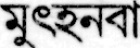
মুৎহনবা
